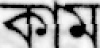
কাম
